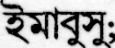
ইমাবুসু;
